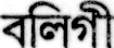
বলিগী
